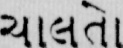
ચાલતો
